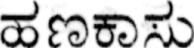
ಹಣಕಾಸು
